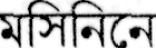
মসিনিনে
